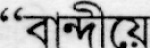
"বান্দীয়ে
